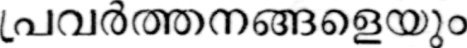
പ്രവര്‍ത്തനങ്ങളെയും
